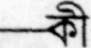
–কী
